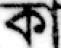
কা
